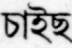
চাইছ
